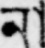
না
